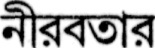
নীরবতার
